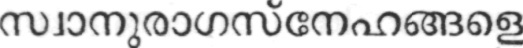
സ്വാനുരാഗസ്നേഹങ്ങളെ
